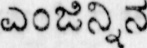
ಎಂಜಿನ್ನಿನ
